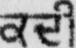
ਕਦੀ
